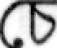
চে
